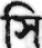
সি
